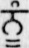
ਨੂੰ
